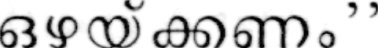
ഒഴയ്ക്കണം”
